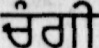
ਚੰਗੀ
